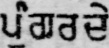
ਪੁੰਗਰਦੇ
